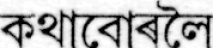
কথাবোৰলৈ
